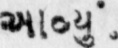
આવ્યું.
